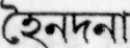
হৈনদনা
